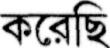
করেছি
